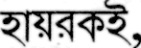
হায়রকই,
